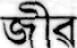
জীৱ
